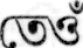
তেওঁ
